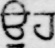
ਉਹ
